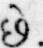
છે.
